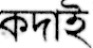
কদাই
